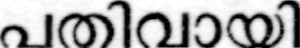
പതിവായി
